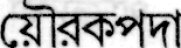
য়ৌরকপদা
